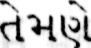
તેમણે
